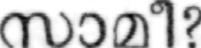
സാമീ?
